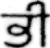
ਭੀ
